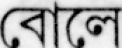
বোলে
